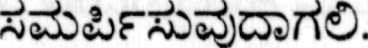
ಸಮರ್ಪಿಸುವುದಾಗಲಿ.
